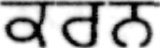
ਕਰਨ
